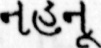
નહનૂ
